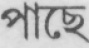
পাছে
